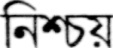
নিশ্চয়
